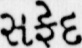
સફેદ
